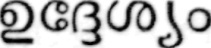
ഉദ്ദേശ്യം
